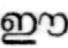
ഈ
